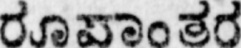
ರೂಪಾಂತರ
